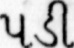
પડી
